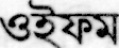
ওইফম
